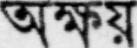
অক্ষয়
